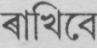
ৰাখিবে
